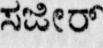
ಸಜೀರ್
